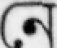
নে
